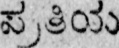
ಪ್ರತಿಯ
